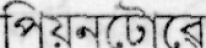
পিয়নটোৱে
